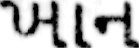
ખાન
